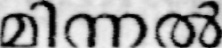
മിന്നല്‍
